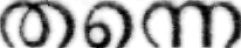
തന്നെ
